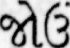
જોઉં
